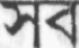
সব
